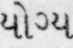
યોગ્ય
